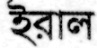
ইরাল
